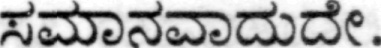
ಸಮಾನವಾದುದೇ.
